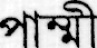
পাম্মী
